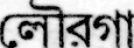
লৌরগা
